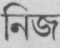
নিজ
